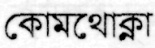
কোমথোক্না
